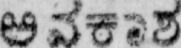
ಅವಕಾಶ
